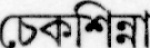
চেকশিন্না
